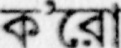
ক'রো
